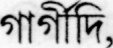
গার্গীদি,
